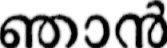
ഞാന്‍
